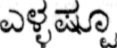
ಎಳ್ಳಷ್ಟೂ
